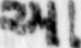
આ
